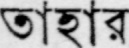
তাহার
